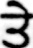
ਤੇ
